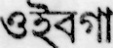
ওইবগা
